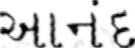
આનંદ
